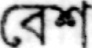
বেশ
